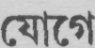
যোগে
